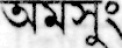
অমসুং
